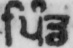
ਪਿੰਡ
